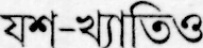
যশ-খ্যাতিও
